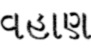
વહાણ
